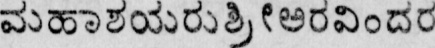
ಮಹಾಶಯರುಶ್ರೀಅರವಿಂದರ
